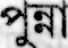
পুন্না
